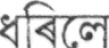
ধৰিলে
